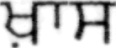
ਖ਼ਾਸ
